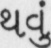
થવું
